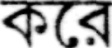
করে
